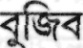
বুজিব
